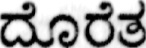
ದೊರೆತ
